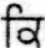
ਕਿ
